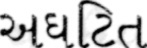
અઘટિત
